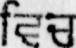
ਵਿਚ
